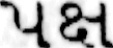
પક્ષ
